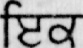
ਇਕ
